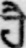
ਹੈ
